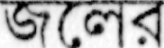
জলের
